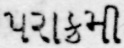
પરાક્રમી
